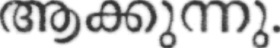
ആക്കുന്നു.
